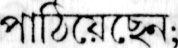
পাঠিয়েছেন;
